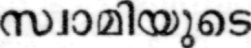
സ്വാമിയുടെ
